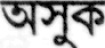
অসুক
